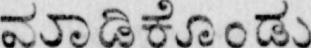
ಮಾಡಿಕೊಂಡು
